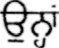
ਉਨ੍ਹਾਂ
